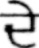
ਦੇ
